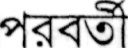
পরবর্তী
